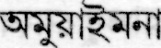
অমুয়াইমনা
